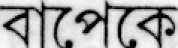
বাপেকে
